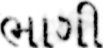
ભાગી
